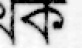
খক
